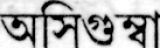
অসিগুম্বা
